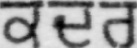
ਕਦਰ
